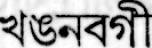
খঙনবগী
